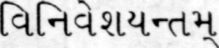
વિનિવેશયન્તમ્
